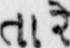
તારે
